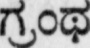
ಗ್ರಂಥ
